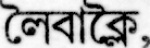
লৈবাক্লৈ,
